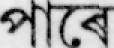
পাৰে
